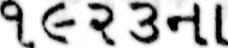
૧૯૨૩ના
